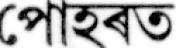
পোহৰত
